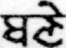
ਬਣੇ
